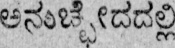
ಅನುಚ್ಛೇದದಲ್ಲಿ
